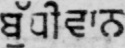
ਬੁੱਧੀਵਾਨ
